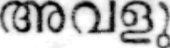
അവളു
